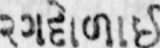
રગદોળાઈ
